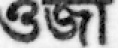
ওজা
